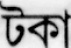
টকা
